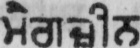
ਮੈਗਜ਼ੀਨ
